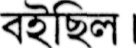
বইছিল।
